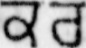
ਕਰ
